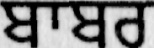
ਬਾਬਰ
